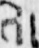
તો
